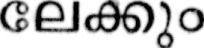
ലേക്കും
